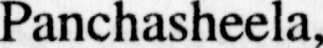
Panchasheela,
